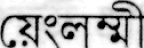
য়েংলম্মী
